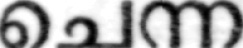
ചെന്ന
